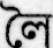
লৈ
